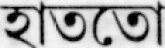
হাততো
